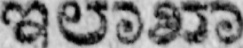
ಇಲಾಖಾ
